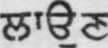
ਲਾਉਣ
